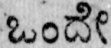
ಒಂದೇ
